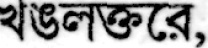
খঙলক্তেরে,
